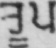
ਰੂਪ
